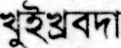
খুইখ্রবদা
